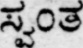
ಸ್ವಂತ
